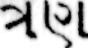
ત્રણ
